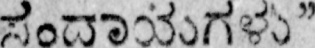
ಸಂದಾಯಗಳು”
